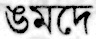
ঙমদে
